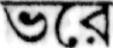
ভরে
